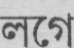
লগে
